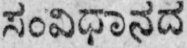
ಸಂವಿಧಾನದ
